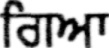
ਗਿਆ
